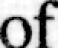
of
